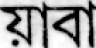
য়াবা
